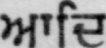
ਆਦਿ
